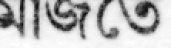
মাজতে
